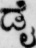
ಡೈ
